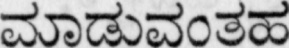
ಮಾಡುವಂತಹ
